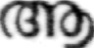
ആ
